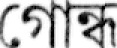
গোন্ধ
